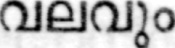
വലവും
